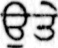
ਉਤੇ
